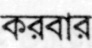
করবার
